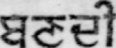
ਬਣਦੀ
